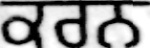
ਕਰਨ
